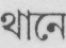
থানে
